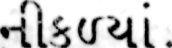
નીકળ્યાં.
